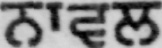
ਨਾਵਲ
